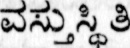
ವಸ್ತುಸ್ಥಿತಿ
